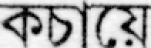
কচায়ে
